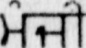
ਮੰਜੀ
